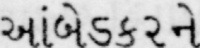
આંબેડકરને
